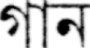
গান
